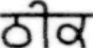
ਠੀਕ
